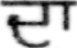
ਦਾ
